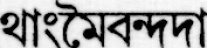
থাংমৈবন্দদা
